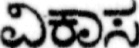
ವಿಕಾಸ
